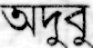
অদুবু
